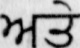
ਅਤੇ
